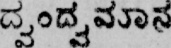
ದ್ವಂದ್ವಮಾನ
